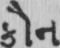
કૌન
